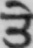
ਤੇ
